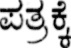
ಪತ್ರಕ್ಕೆ
